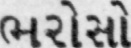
ભરોસો
